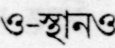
ও-স্থানও
